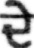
ਦੇ
